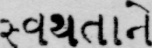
સ્વસ્થતાને
